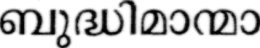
ബുദ്ധിമാന്മാ
